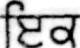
ਇਕ
